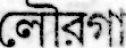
লৌরগা
